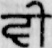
ਵੀ
